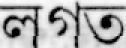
লগত
